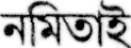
নমিতাই
